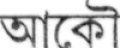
আকৌ
